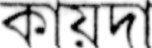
কায়দা
